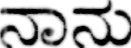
ನಾನು
